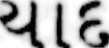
યાદ
